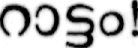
റാട്ടം!
